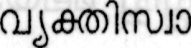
വ്യക്തിസ്വാ
